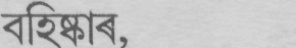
বহিষ্কাৰ,
